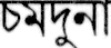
চমদুনা
